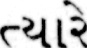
ત્યારે
